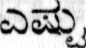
ಎಷ್ಟು
